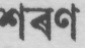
শৰণ
